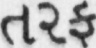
તરફ
